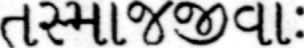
તસ્માજજીવાઃ
